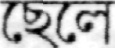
ছেলে
